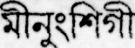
মীনুংশিগী
